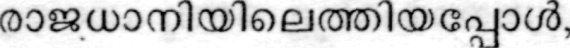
രാജധാനിയിലെത്തിയപ്പോള്‍,
